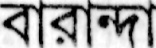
বারান্দা
